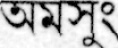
অমসুং
